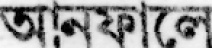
আনফালে
